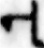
ન
